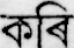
কৰি
